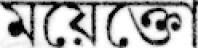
ময়েক্তো
